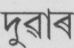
দুৱাৰ
